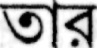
তার
